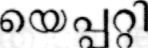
യെപ്പറ്റി
